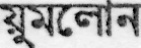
য়ুমলোন
